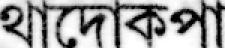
থাদোকপা
